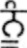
ਨੂੰ
